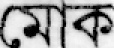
মোক
